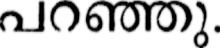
പറഞ്ഞു.
